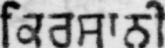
ਕਿਰਸਾਨੀ
